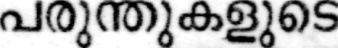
പരുന്തുകളുടെ
